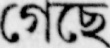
গেছে
